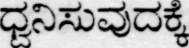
ಧ್ವನಿಸುವುದಕ್ಕೆ
